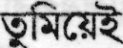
তুমিয়েই
